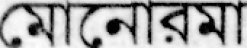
মোনোরমা
